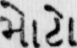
મોટો
